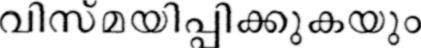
വിസ്മയിപ്പിക്കുകയും
